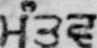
ਮੰਤਵ
